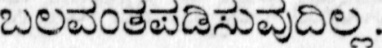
ಬಲವಂತಪಡಿಸುವುದಿಲ್ಲ.
